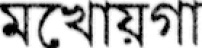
মখোয়গা
